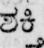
ಶಕ್ತಿ
